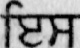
ਇਸ
